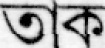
তাক
